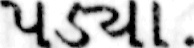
પડ્યા.
